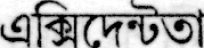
এক্সিদেন্টতা
